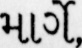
માર્ગે,
